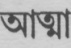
আত্মা
